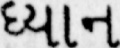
ધ્યાન
